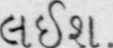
લઈશ.
